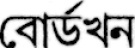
বোর্ডখন
